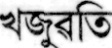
খজুৱতি
